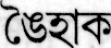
ঙৈহাক
